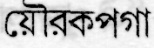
য়ৌরকপগা
